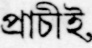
প্রাচীই,
